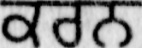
ਕਰਨ
